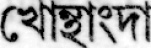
খোন্থাংদা
